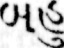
બહુ
